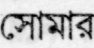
সোমার
